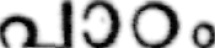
പാഠം
